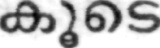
കൂടെ
